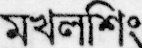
মখলশিং
